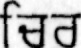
ਚਿਰ
